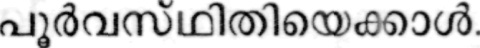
പൂര്‍വസ്ഥിതിയെക്കാള്‍.
